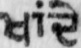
ਖਾਂਦੇ
